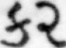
કર
